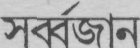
সৰ্ব্বজান
